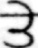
ਤੇ
